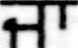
ਜਾ
